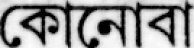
কোনোবা
